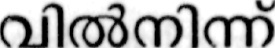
വില്‍നിന്ന്
